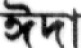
ঈদা
